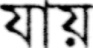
যায়
